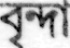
বৃন্দা
